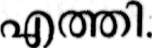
എത്തി.
